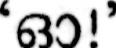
'ഓ!’
